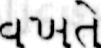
વખતે
